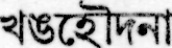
খঙহৌদনা
